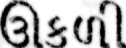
ઊકળી
